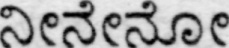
ನೀನೇನೋ
